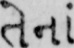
તેનાં
